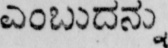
ಎಂಬುದನ್ನು
